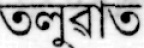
তলুৱাত
